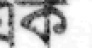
এক
